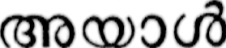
അയാള്‍
